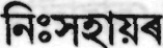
নিঃসহায়ৰ
